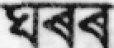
ঘৰৰ
